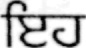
ਇਹ
